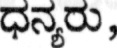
ಧನ್ಯರು,
